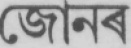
জোনৰ
